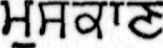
ਮੁਸਕਾਣ
